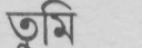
তুমি
